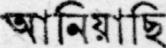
আনিয়াছি
